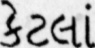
કેટલાં
